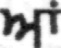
ਆਂ
